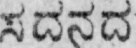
ಸದನದ
